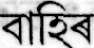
বাহিৰ
